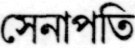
সেনাপতি
